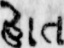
હોત
